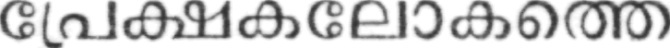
പ്രേക്ഷകലോകത്തെ
